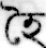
হৈ
